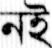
নই
